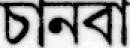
চানবা
